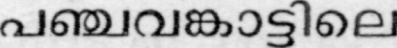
പഞ്ചവങ്കാട്ടിലെ
